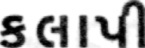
કલાપી
